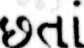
છતાં
